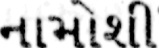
નામોશી
